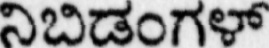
ನಿಬಿಡಂಗಳ್
